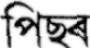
পিছৰ
